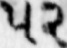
પર
